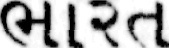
ભારત
